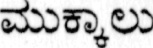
ಮುಕ್ಕಾಲು
